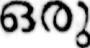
ഒരു
